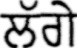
ਲੱਗੇ
